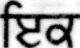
ਇਕ
